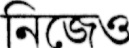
নিজেও
